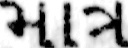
માત્ર
